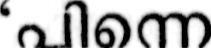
‘പിന്നെ
